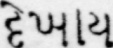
દેખાય
